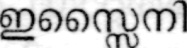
ഇസ്സൈനി
